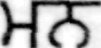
ਮਨ
